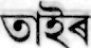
তাইৰ
